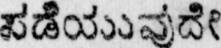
ಪಡೆಯುವುದೇ
